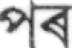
পৰ
